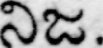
ನಿಜ.
